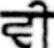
ਵੀ
